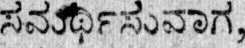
ಸಮರ್ಥಿಸುವಾಗ,
